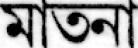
মাতনা
